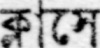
ক্লাসে
